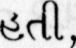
હતી,
